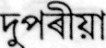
দুপৰীয়া
